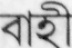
বাহী
